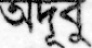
অদূবু
